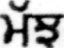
ਮੱਝ
